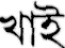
খাই
